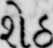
શેઠ
